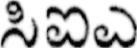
ಸಿಐಎ
